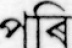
পৰি
